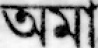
অমা
